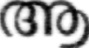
ആ
